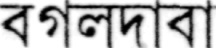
বগলদাবা
